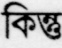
কিন্তু
